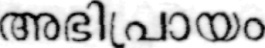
അഭിപ്രായം
